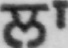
ਲਾ
